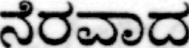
ನೆರವಾದ
